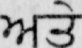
ਅਤੇ
